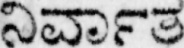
ನಿರ್ವಾತ
